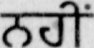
ਨਹੀਂ
